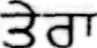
ਤੇਰਾ
